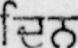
ਦਿਨ
